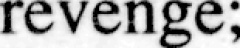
revenge;
